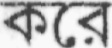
করে
